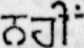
ਨਹੀਂ
